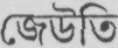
জেউতি
